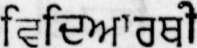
ਵਿਦਿਆਰਥੀ
